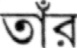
তাঁর
